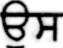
ਉਸ
